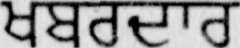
ਖਬਰਦਾਰ
